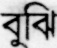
বুঝি
